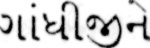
ગાંધીજીને
